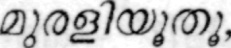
മുരളിയൂതൂ,
